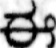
ಈ
